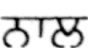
ਨਾਲ
